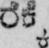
ರೆಕ್ಕೆ
